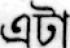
এটা
